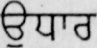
ਉਧਾਰ
